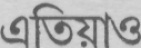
এতিয়াও
